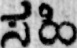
ಸಹಿ
